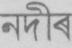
নদীৰ
